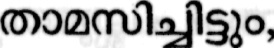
താമസിച്ചിട്ടും,
